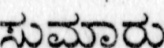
ಸುಮಾರು
